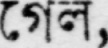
গেল,
